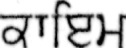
ਕਾਇਮ
